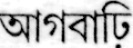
আগবাঢ়ি
